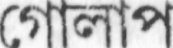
গোলাপ
